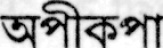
অপীকপা
